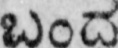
ಬಂದ
